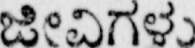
ಜೀವಿಗಳು
